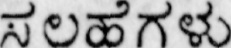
ಸಲಹೆಗಳು
